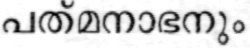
പത്മനാഭനും
